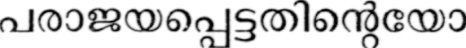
പരാജയപ്പെട്ടതിന്റെയോ
